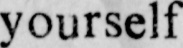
yourself
